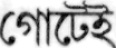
গোটেই
